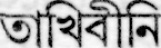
তাখিবীনি
